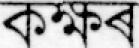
কক্ষৰ
